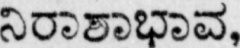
ನಿರಾಶಾಭಾವ,
